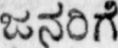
ಜನರಿಗೆ
